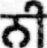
ਨੀ
